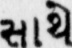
સાથે
